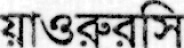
য়াওরুরসি
